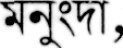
মনুংদা,
